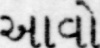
આવો
